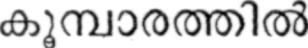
കൂമ്പാരത്തില്‍
